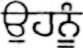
ਉਹਨੂੰ
